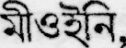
মীওইনি,
